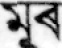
মূৰ
